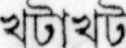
খটাখট
